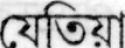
যেতিয়া
